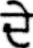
ਦੇ
